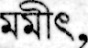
মমীৎ,
